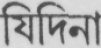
যিদিনা
